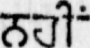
ਨਹੀਂ
